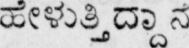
ಹೇಳುತ್ತಿದ್ದಾನೆ
